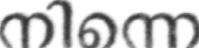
നിന്നെ
